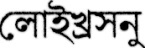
লোইখ্রসনু
